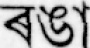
ৰঙা
